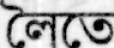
লৈতে
